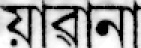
য়াৱানা
